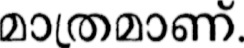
മാത്രമാണ്.
